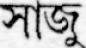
সাজু
